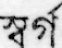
স্বর্গ
